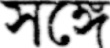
সঙ্গে
